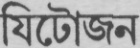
যিটোজন
